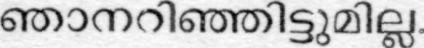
ഞാനറിഞ്ഞിട്ടുമില്ല.
